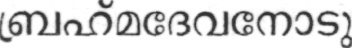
ബ്രഹ്മദേവനോടു
